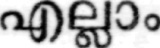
എല്ലാം
